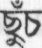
ছুঁচ
